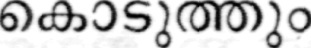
കൊടുത്തും
